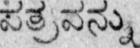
ಪತ್ರವನ್ನು
